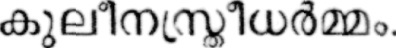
കുലീനസ്ത്രീധര്‍മ്മം.
